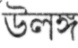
উলঙ্গ
